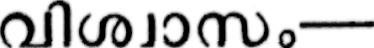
വിശ്വാസം-
